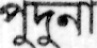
পুদুনা
